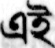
এই
